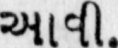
આવી.
